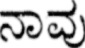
ನಾವು
